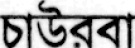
চাউরবা
